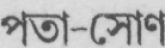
পতা-সোণ
